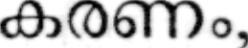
കരണം,
